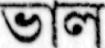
ভাল
